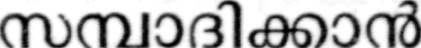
സമ്പാദിക്കാന്‍
